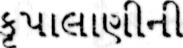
કૃપાલાણીની
